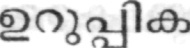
ഉറുപ്പിക
